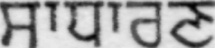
ਸਾਧਾਰਣ
